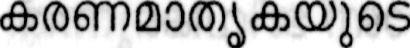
കരണമാതൃകയുടെ
